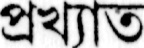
প্রখ্যাত
